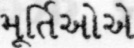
મૂર્તિઓએ
